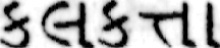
કલકત્તા
